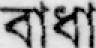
বাধা
